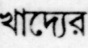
খাদ্যের
